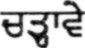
ਚੜ੍ਹਾਵੇ
